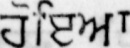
ਹੋਇਆ
